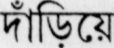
দাঁড়িয়ে
